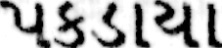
પકડાયા
